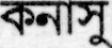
কনাসু
